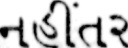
નહીંતર
